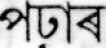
পঢ়াৰ
